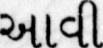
આવી
